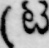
(ಟ
